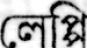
লেপ্পি
